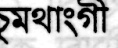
চুমথাংগী
